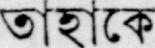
তাহাকে
